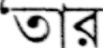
‘তার
